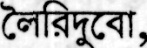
লৈরিদুবো
